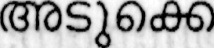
അടുക്കെ
